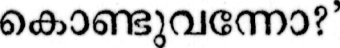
കൊണ്ടുവന്നോ?'
